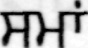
ਸਮਾਂ
